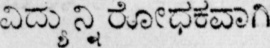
ವಿದ್ಯುನ್ನಿರೋಧಕವಾಗಿ
